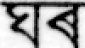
ঘৰ
